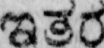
ಇತರ
